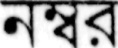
নম্বর
